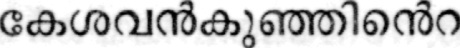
കേശവന്‍കുഞ്ഞിന്റെ
